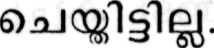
ചെയ്തിട്ടില്ല.
